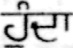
ਹੁੰਦਾ
